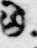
છે.
